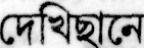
দেখিছানে
